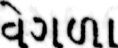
વેગળા
